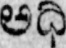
ಅಧಿ
